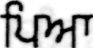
ਪਿਆ
